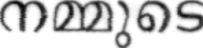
നമ്മുടെ
